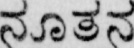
ನೂತನ
